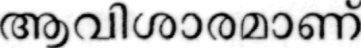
ആവിശാരമാണ്
